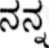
ನನ್ನ
